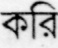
করি
